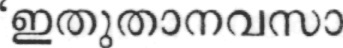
"ഇതുതാനവസാ
